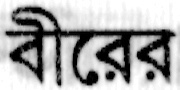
বীরের
